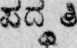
ಪದ್ಧತಿ
